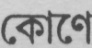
কোণে
